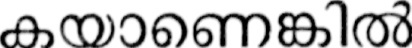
കയാണെങ്കില്‍
